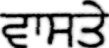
ਵਾਸਤੇ
